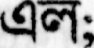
এল;
